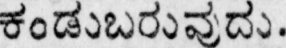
ಕಂಡುಬರುವುದು.
